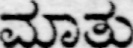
ಮಾತು
